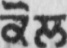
ਕੋਲ
